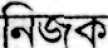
নিজক
